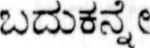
ಬದುಕನ್ನೇ
